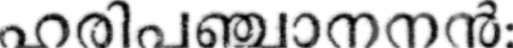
ഹരിപഞ്ചാനനന്‍:
